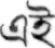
এই
